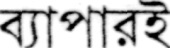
ব্যাপারই
